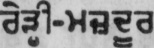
ਰੇੜ੍ਹੀ-ਮਜ਼ਦੂਰ
